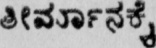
ತೀರ್ಮಾನಕ್ಕೆ
